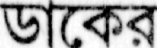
ডাকের
